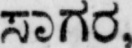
ಸಾಗರ,
